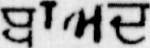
ਬਾਅਦ
